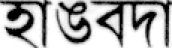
হাঙবদা
